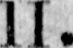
II.
